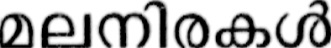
മലനിരകള്‍
